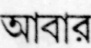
আবার
